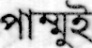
পাম্মুই
